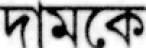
দামকে
